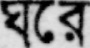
ঘরে
